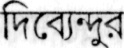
দিব্যেন্দুর
